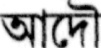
আদৌ
